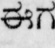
ಈಗ
